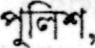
পুলিশ,
